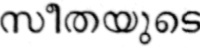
സീതയുടെ
